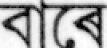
বাৰে
